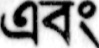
এবং
